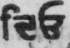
ਦਿਓ
